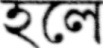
হলে
